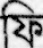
ফি
